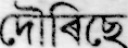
দৌৰিছে
